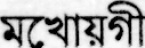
মখোয়গী
